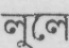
লুলে
